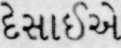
દેસાઈએ
